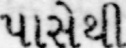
પાસેથી
